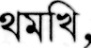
থমখি,
